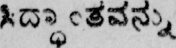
ಸಿದ್ದಾಂತವನ್ನು
